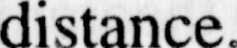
distance
